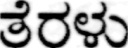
ತೆರಳು
